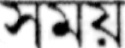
সময়
